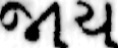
જાય
